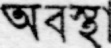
অবস্থা
